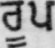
ਰੂਪ
